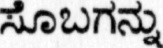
ಸೊಬಗನ್ನು
